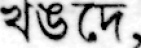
খঙদে,
